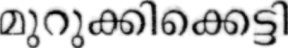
മുറുക്കിക്കെട്ടി
